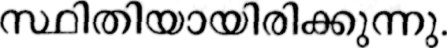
സ്ഥിതിയായിരിക്കുന്നു.
